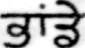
ਭਾਂਡੇ
